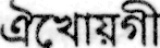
ঐখোয়গী
